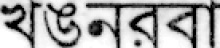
খঙনরবা
